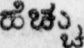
ಹೆಚ್ಚು
